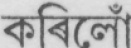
কৰিলোঁ
